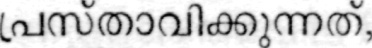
പ്രസ്താവിക്കുന്നത്,
